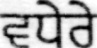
ਵਧੇਰੇ
